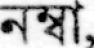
নম্বা,
